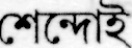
শেন্দোই
